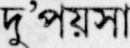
দু'পয়সা
